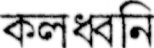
কলধ্বনি
